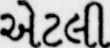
એટલી
